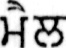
ਮੈਲ
